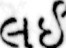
લર્ઘ
